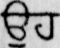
ਉਹ
